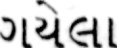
ગયેલા
